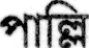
পাল্লি
